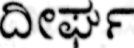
ದೀರ್ಘ
